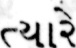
ત્યારે
